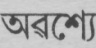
অৱশ্যে
